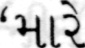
'મારે
